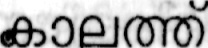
കാലത്ത്
